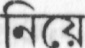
নিয়ে
